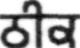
ਠੀਕ
